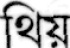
থিয়
